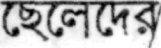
ছেলেদের
